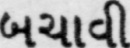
બચાવી
